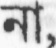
না,
